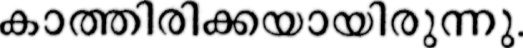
കാത്തിരിക്കയായിരുന്നു.
